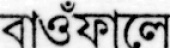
বাওঁফালে
